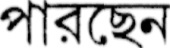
পারছেন
